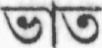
ভাত
